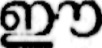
ഈ
